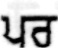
ਪਰ
